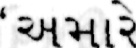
'અમારે
